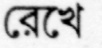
রেখে
